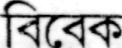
বিবেক
